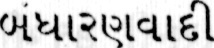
બંધારણવાદી
